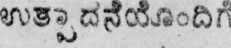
ಉತ್ಪಾದನೆಯೊಂದಿಗೆ
